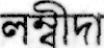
লম্বীদা
